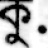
কু.
